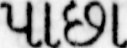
પાછા
